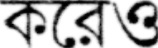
করেও
